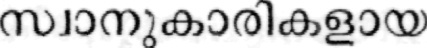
സ്വാനുകാരികളായ
